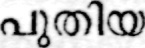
പുതിയ
